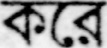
করে
